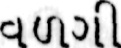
વળગી
